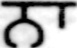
ਨਾ
